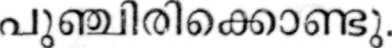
പുഞ്ചിരിക്കൊണ്ടു.
